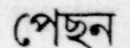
পেছন
